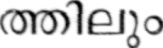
ത്തിലും
